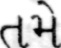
તમે
